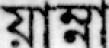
য়াম্না
